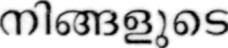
നിങ്ങളുടെ
